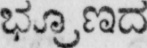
ಭ್ರೂಣದ
